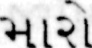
મારો
